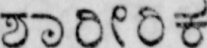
ಶಾರೀರಿಕ
